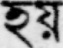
হয়
